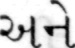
અને
